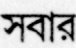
সবার
